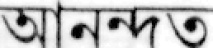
আনন্দত
